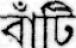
বাঁটি
